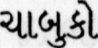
ચાબુકો
